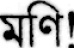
মণি!
